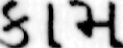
કામ
